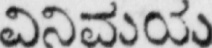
ವಿನಿಮಯ
